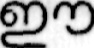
ഈ
